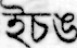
ইচঙ
